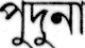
পুদুনা
